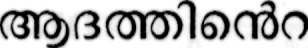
ആദത്തിന്റെ
